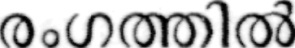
രംഗത്തില്‍
